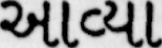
આવ્યા
